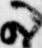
જે
